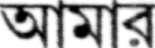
আমার
